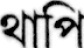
থাপি
